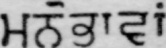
ਮਨੋਭਾਵਾਂ
